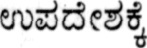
ಉಪದೇಶಕ್ಕೆ
